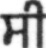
ਸੀ
